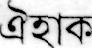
ঐহাক
